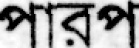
পারপ
